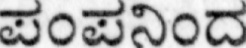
ಪಂಪನಿಂದ
